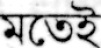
মতেই
